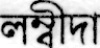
লম্বীদা
